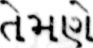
તેમણે
